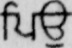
ਪਿਉ
